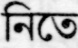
নিতে
